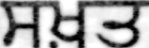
ਸਖ਼ਤ
